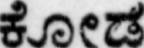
ಕೋಡ
